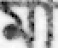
মা
